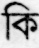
কি
